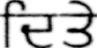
ਦਿਤੇ
